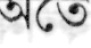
অতৈ
